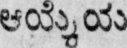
ಆಯ್ಕೆಯ
